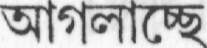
আগলাচ্ছে
